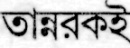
তান্নরকই
